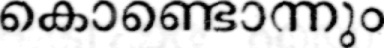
കൊണ്ടൊന്നും
